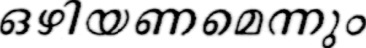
ഒഴിയണമെന്നും
